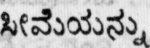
ಸೀಮೆಯನ್ನು
